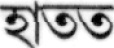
হাতত
